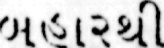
બહારથી
